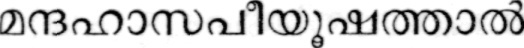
മന്ദഹാസപീയൂഷത്താല്‍
